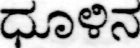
ಧೂಳಿನ
